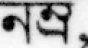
নম্র,
